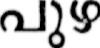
പുഴ
